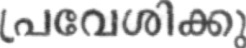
പ്രവേശിക്കു
